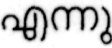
എന്നു
